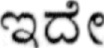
ಇದೇ
